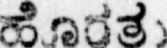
ಹೊರತು
